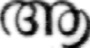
ആ
